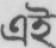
এই
